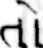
તો
